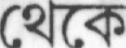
থেকে
